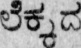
ಲೆಕ್ಕದ
